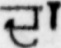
ਦਾ
